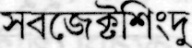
সবজেক্টশিংদু
